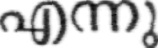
എന്നു
